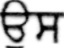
ਉਸ
